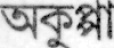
অকুপ্পা
